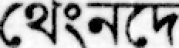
থেংনদে
